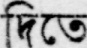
দিতে
